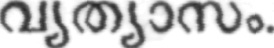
വ്യത്യാസം.
